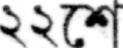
২২শে
